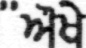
''ਔਖੇ
